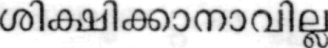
ശിക്ഷിക്കാനാവില്ല
